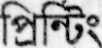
প্রিন্টিং
